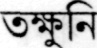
তক্ষুনি
